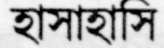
হাসাহাসি
